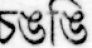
চঙঙি
